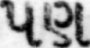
પણ
